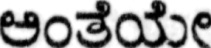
ಅಂತೆಯೇ
